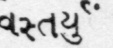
વિસ્તર્યું
